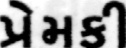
પ્રેમકી
